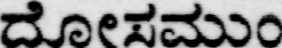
ದೋಸಮುಂ
